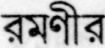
রমণীর
